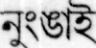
নুংঙাই
